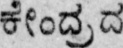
ಕೇಂದ್ರದ
